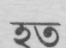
হত
